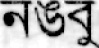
নঙবু
